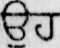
ਉਹ
